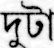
দুটা
